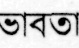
ভাবতা
